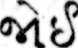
જોઈ
